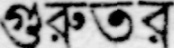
গুরুতর
